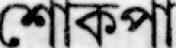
শোকপা
